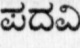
ಪದವಿ
